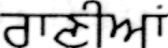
ਰਾਣੀਆਂ
